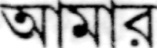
আমার
